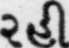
રહી
